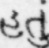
હતું
